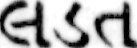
લડત
